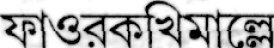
ফাওরকখিমাল্লে
